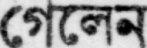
গেলেন
